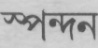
স্পন্দন
